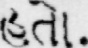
હતો.
